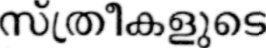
സ്ത്രീകളുടെ
